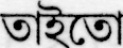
তাইতো
